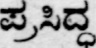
ಪ್ರಸಿದ್ಧ
